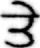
ਤੇ
